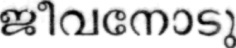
ജീവനോടു
